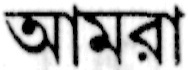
আমরা
